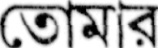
তোমার
